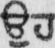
ਉਹ
